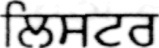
ਲਿਸਟਰ
